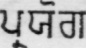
ਪ੍ਰਯੋਗ
